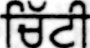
ਚਿੱਟੀ
